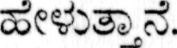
ಹೇಳುತ್ತಾನೆ.
